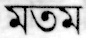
মতম
